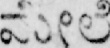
ಮೇಲೆ
